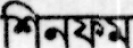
শিনফম
